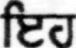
ਇਹ
